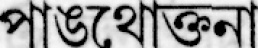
পাঙথোক্তনা
